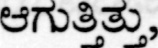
ಆಗುತ್ತಿತ್ತು,
